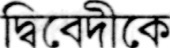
দ্বিবেদীকে
